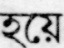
হয়ে
